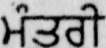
ਮੰਤਰੀ
